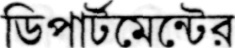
ডিপার্টমেন্টের
